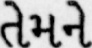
તેમને
